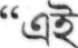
"এই
